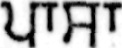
ਪਾਸਾ
